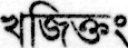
খজিক্তং
